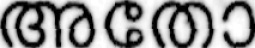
അതോ
